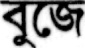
বুজে
